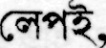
লেপই,
